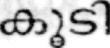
കൂടി
